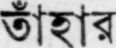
তাঁহার
